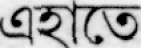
এহাতে
